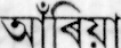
আঁৰিয়া
